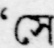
‘সে
